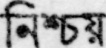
নিশ্চয়
